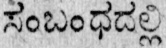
ಸಂಬಂಧದಲ್ಲಿ
